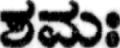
ಶಮಃ
